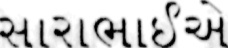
સારાભાઈએ
